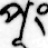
পূং
